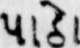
પાઠો
